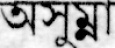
অসুম্না
